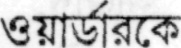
ওয়ার্ডারকে
